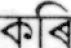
কৰি
